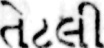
તેટલી
